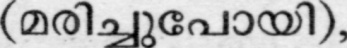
(മരിച്ചുപോയി),
